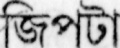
জিপটা
